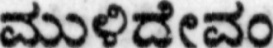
ಮುಳಿದೇವಂ
